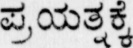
ಪ್ರಯತ್ನಕ್ಕೆ
